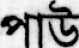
পাউ
